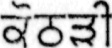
ਕੋਠੜੀ
